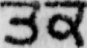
ਤਕ
